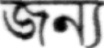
জন্য
